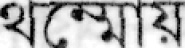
থম্মোয়
